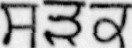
ਸੜਕ
